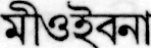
মীওইবনা
